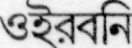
ওইরবনি
